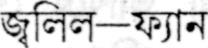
জ্বলিল—ফ্যান
